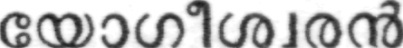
യോഗീശ്വരന്‍
